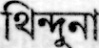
থিন্দুনা
